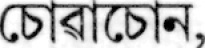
চোৱাচোন,
